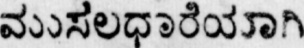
ಮುಸಲಧಾರೆಯಾಗಿ
